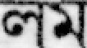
লম
